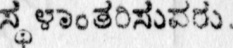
ಸ್ಥಳಾಂತರಿಸುವರು.
